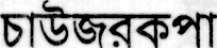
চাউজরকপা
